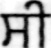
ਸੀ
